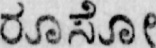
ರೂಸೋ
